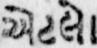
એટલો
